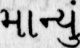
માન્યું
